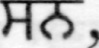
ਸਨ,
